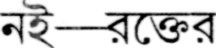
নই–রক্তের
